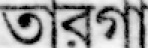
তারগা
